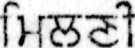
ਮਿਲਣੀ
